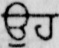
ਉਹ
